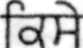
ਕਿਸੇ
